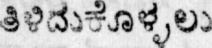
ತಿಳಿದುಕೊಳ್ಳಲು
